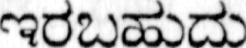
ಇರಬಹುದು
